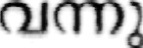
വന്നു
